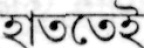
হাততেই
